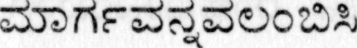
ಮಾರ್ಗವನ್ನವಲಂಬಿಸಿ
